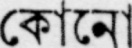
কোনো
